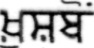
ਖ਼ੁਸ਼ਬੋਂ
